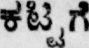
ಕಟ್ಟಿಗೆ
